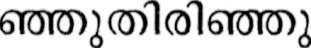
ഞ്ഞുതിരിഞ്ഞു
